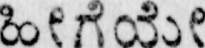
ಹೀಗೆಯೇ
